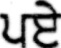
ਪਏ
